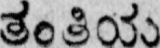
ತಂತಿಯ
